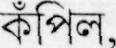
কঁপিল,
